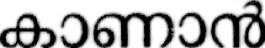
കാണാന്‍
